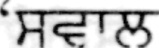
'ਸਵਾਲ
